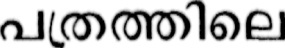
പത്രത്തിലെ
